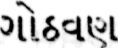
ગોઠવણ
